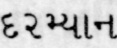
દરમ્યાન
